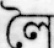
লৈ
